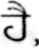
ਹੈ,
